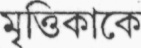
মৃত্তিকাকে
